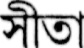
সীতা
